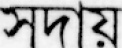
সদায়
